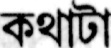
কথাটা
